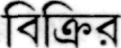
বিক্রির
